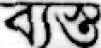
ব্যস্ত
